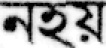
নহয়
